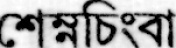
শেম্নচিংবা
